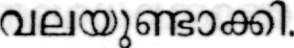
വലയുണ്ടാക്കി.
